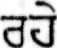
ਰਹੇ
